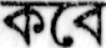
কবে
